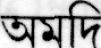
অমদি
